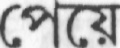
পেয়ে
